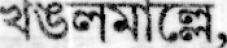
খঙলমাল্লে,
